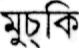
মুচ্কি
